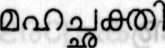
മഹച്ഛക്തി
